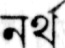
নর্থ
